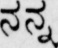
ನನ್ನ
